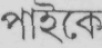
পাইকে
